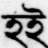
হই
